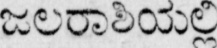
ಜಲರಾಶಿಯಲ್ಲಿ
